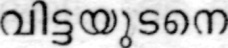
വിട്ടയുടനെ
